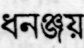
ধনঞ্জয়
